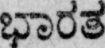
ಭಾರತ
